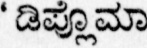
‘ಡಿಪ್ಲೊಮಾ
